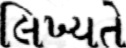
લિખ્યતે
